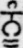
ਨੂੰ
